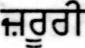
ਜ਼ਰੂਰੀ
